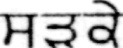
ਸੜਕੇ
